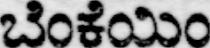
ಬೆಂಕೆಯಿಂ
